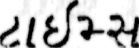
ટાઇમ્સ
